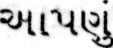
આપણું
